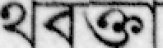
থবক্তা
